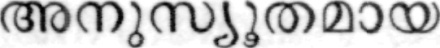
അനുസ്യൂതമായ
